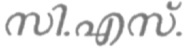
സി.എസ്.
